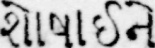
શોષાઈને
